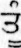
ਤੂੰ
